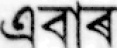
এবাৰ
